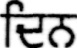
ਦਿਨ
